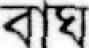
বাঘ
